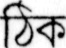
ঠিক
